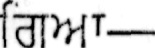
ਗਿਆ--
